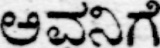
ಅವನಿಗೆ
